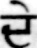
ਦੇ
